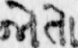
જોતો
